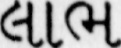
લાભ
